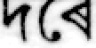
দৰে
